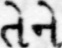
તેને
